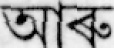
আৰু
